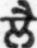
ਲੈ
